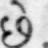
છે.
